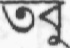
তবু
